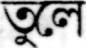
তুলে
